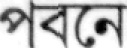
পবনে
